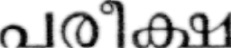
പരീക്ഷ
